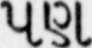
પણ
